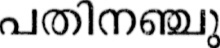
പതിനഞ്ചു
